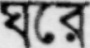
ঘরে
